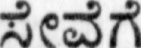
ಸೇವೆಗೆ
